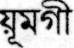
য়ূমগী
